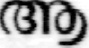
ആ
